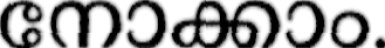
നോക്കാം.
